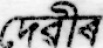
দেৱীৰ
